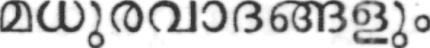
മധുരവാദങ്ങളും
